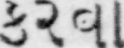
કરવા
